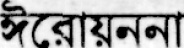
ঈরোয়ননা
